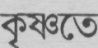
কৃষ্ণতে
